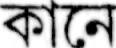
কানে
